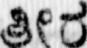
ತೀರ
